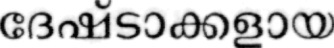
ദേഷ്ടാക്കളായ
